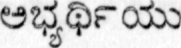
ಅಭ್ಯರ್ಥಿಯು
